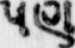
તેનો
